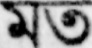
মত
